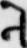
ને
